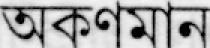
অকণমান
